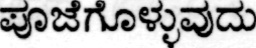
ಪೂಜೆಗೊಳ್ಳುವುದು
